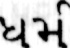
ધર્મ
